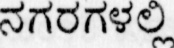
ನಗರಗಳಲ್ಲಿ
